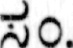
ಸಂ.
